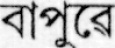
বাপুৱে
